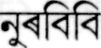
নুৰবিবি
